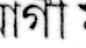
মাগী
